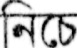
নিচে
